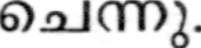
ചെന്നു.
